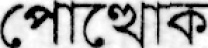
পোত্থোক
